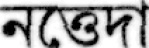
নত্তেদা
